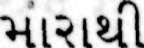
મારાથી
